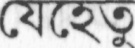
যেহেতু
